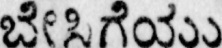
ಬೇಸಿಗೆಯು
